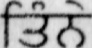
ਤਿੰਨੇ
